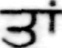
ਤਾਂ
